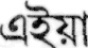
এইয়া
